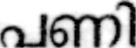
പണി
